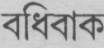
বধিবাক
